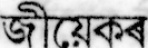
জীয়েকৰ
